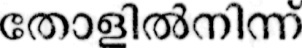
തോളില്‍നിന്ന്
